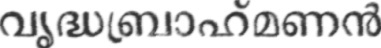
വൃദ്ധബ്രാഹ്മണന്‍
